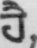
ਹੈ,
